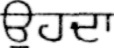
ਉਹਦਾ
